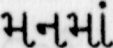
મનમાં
